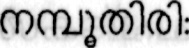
നമ്പൂതിരി:
